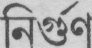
নিৰ্গুণ
